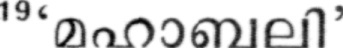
19'മഹാബലി'
